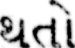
થતો
